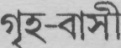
গৃহ-বাসী
